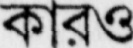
কারও
